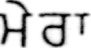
ਮੇਰਾ
